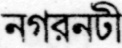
নগরনটী
